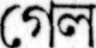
গেল
